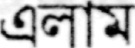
এলাম
